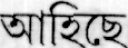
আহিছে
